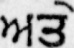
ਅਤੇ
